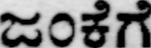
ಜಂಕೆಗೆ
